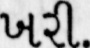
ખરી.
